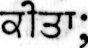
ਕੀਤਾ;
